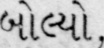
બોલ્યો,
